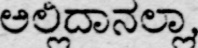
ಅಲ್ಲಿದಾನಲ್ಲಾ,
